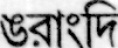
ঙরাংদি
